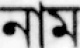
নাম
